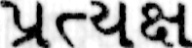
પ્રત્યક્ષ
